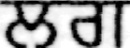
ਲਗ
